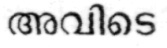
അവിടെ
